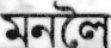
মনলৈ
